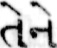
તેને
